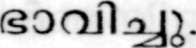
ഭാവിച്ചു.
